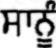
ਸਾਨੂੰ
